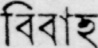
বিবাহ
